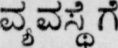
ವ್ಯವಸ್ಥೆಗೆ
